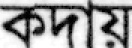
কদায়
